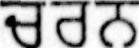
ਚਰਨ
